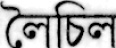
লৈচিল
